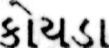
કોયડા
